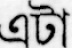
এটা
